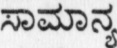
ಸಾಮಾನ್ಯ
